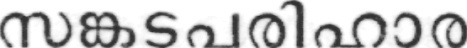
സങ്കടപരിഹാര
